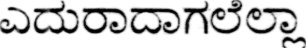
ಎದುರಾದಾಗಲೆಲ್ಲಾ
